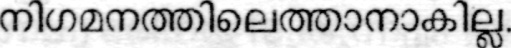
നിഗമനത്തിലെത്താനാകില്ല.
